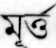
মূর্ত্ত
